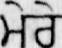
ਮੇਰੇ
